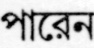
পারেন
